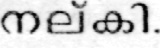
നല്കി.
